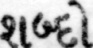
શબ્દો
